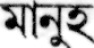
মানুহ
